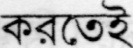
করতেই
